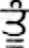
ਤੂੰ
